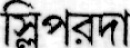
স্লিপরদা
